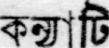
কন্যাটি
